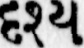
દશ્ય
